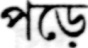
পড়ে
